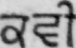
ਕਵੀ
